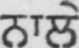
ਨਾਲੇ
